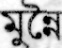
মুন্নৈ
